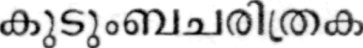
കുടുംബചരിത്രക
